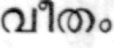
വീതം
